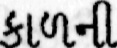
કાળની
